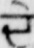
ਦੇ
